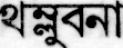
থম্লুবনা
